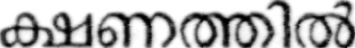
ക്ഷണത്തില്‍
